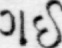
ગઈ
